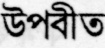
উপবীত
